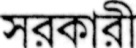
সরকারী
